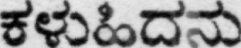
ಕಳುಹಿದನು
